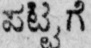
ಪಟ್ಟಿಗೆ
